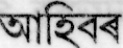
আহিবৰ
